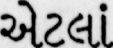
એટલાં
